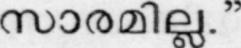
സാരമില്ല.”
